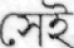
সেই
